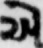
એ
